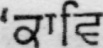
'ਕਾਵਿ
